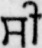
ਸੀ
